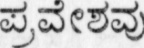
ಪ್ರವೇಶವು
